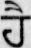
ਹੈ
